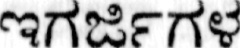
ಇಗರ್ಜಿಗಳ
